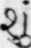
શું
